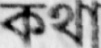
কথা
